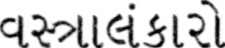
વસ્ત્રાલંકારો
